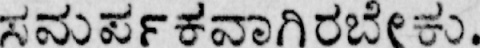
ಸಮರ್ಪಕವಾಗಿರಬೇಕು.
